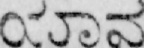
ಯಾವ
